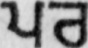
ਪਰ
